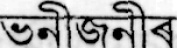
ভনীজনীৰ
